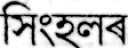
সিংহলৰ
